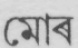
মোৰ
